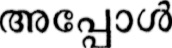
അപ്പോള്‍
